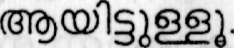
ആയിട്ടുള്ളൂ.
